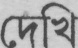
দেখি
